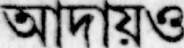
আদায়ও
